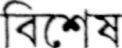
বিশেষ
